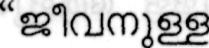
"ജീവനുള്ള
